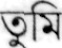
তুমি
